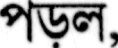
পড়ল,
